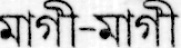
মাগী-মাগী
